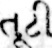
તૂટી
